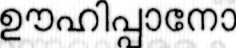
ഊഹിപ്പാനോ
